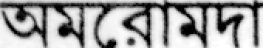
অমরোমদা
